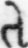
તે
